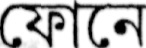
ফোনে
